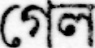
গেল
